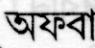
অফবা
